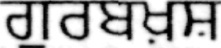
ਗੁਰਬਖ਼ਸ਼
